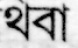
থিবা
